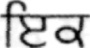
ਇਕ
